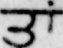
ਤਾਂ
